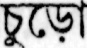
চুড়ো
